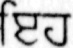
ਇਹ
